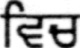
ਵਿਚ
